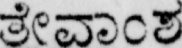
ತೇವಾಂಶ
